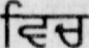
ਵਿਚ
